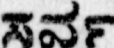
ಸರ್ವ
